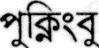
পুক্নিংবু
